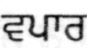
ਵਪਾਰ
